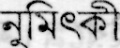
নুমিৎকী
